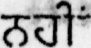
ਨਹੀਂ
